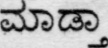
ಮಾಡ್ತಾ
